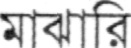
মাঝারি
